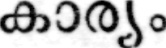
കാര്യം
